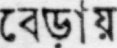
বেড়ায়
